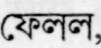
ফেলল,
